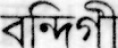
বন্দিগী
